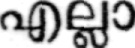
എല്ലാ
